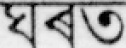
ঘৰত
